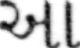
આ
